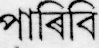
পাৰিবি
